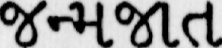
જન્મજાત
